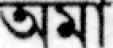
অমা
